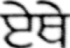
ਏਥੇ
